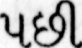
પછી
